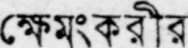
ক্ষেমংকরীর
